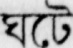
ঘটে
